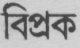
বিপ্ৰক
